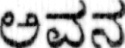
ಅವನ
